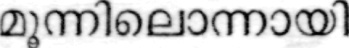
മൂന്നിലൊന്നായി
